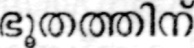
ഭൂതത്തിന്
